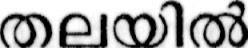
തലയില്‍
